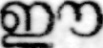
ഈ
